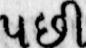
પછી
